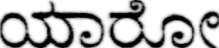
ಯಾರೋ
